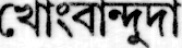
খোংবান্দুদা
